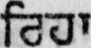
ਰਿਹਾ
